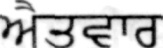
ਐਤਵਾਰ
